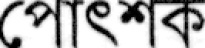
পোৎশক
